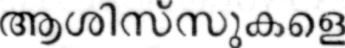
ആശിസ്സുകളെ
